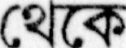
থেকে
